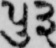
પુરૂ
